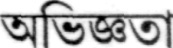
অভিজ্ঞতা
